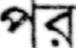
পর
